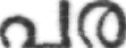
പര
